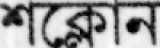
শক্লোন
